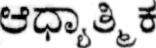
ಆಧ್ಯಾತ್ಮಿಕ
